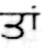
ਤਾਂ
